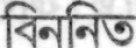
বিননিত
